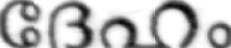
ദേഹം
